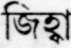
জিহ্বা
